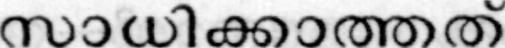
സാധിക്കാത്തത്
